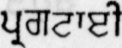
ਪ੍ਰਗਟਾਈ
